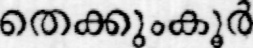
തെക്കുംകൂര്‍
